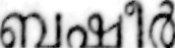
ബഷീര്‍
